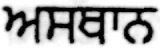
ਅਸਥਾਨ
